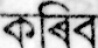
কৰিব
